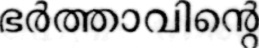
ഭര്‍ത്താവിന്റെ
